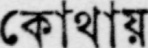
কোথায়
